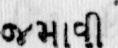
જમાવી
